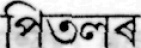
পিতলৰ
